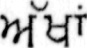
ਅੱਖਾਂ
